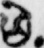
છે.
